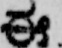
ಈ
